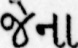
જેના
